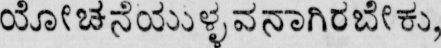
ಯೋಚನೆಯುಳ್ಳವನಾಗಿರಬೇಕು,
